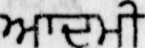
ਆਦਮੀ
